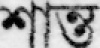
শান্ত
